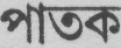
পাতক
